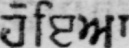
ਹੋਇਆ
